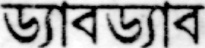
ড্যাবড্যাব
